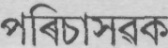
পৰিচাসৱক
